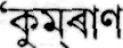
'কুম্‌ৰাণ
